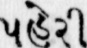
પહેરી
